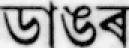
ডাঙৰ
